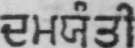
ਦਮਯੰਤੀ
